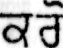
ਕਰੋ
